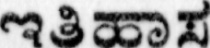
ಇತಿಹಾಸ
